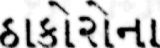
ઠાકોરોના
